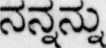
ನನ್ನನ್ನು
